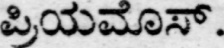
ಪ್ರಿಯಮೊಸ್.
